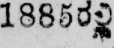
1885ರಲ್ಲಿ
